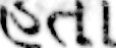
હતા
